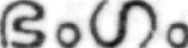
ഭംഗം
